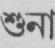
শুনা
